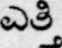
ಎತ್ತಿ
